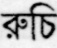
রুচি
